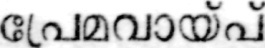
പ്രേമവായ്പ്
